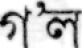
গ'ল
